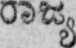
ರಾಜ್ಯ
